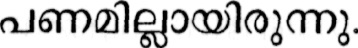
പണമില്ലായിരുന്നു.
